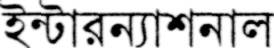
ইন্টারন্যাশনাল
